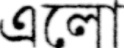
এলো
